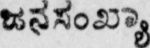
ಜನಸಂಖ್ಯಾ
